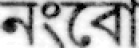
নংবো
